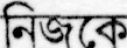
নিজকে
